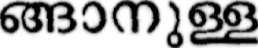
ങ്ങാനുള്ള
